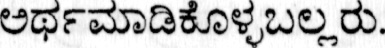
ಅರ್ಥಮಾಡಿಕೊಳ್ಳಬಲ್ಲರು.
